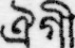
ঐগী
